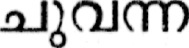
ചുവന്ന
